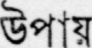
উপায়
